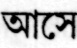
আসে
